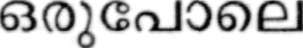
ഒരുപോലെ
